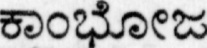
ಕಾಂಭೋಜ
